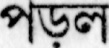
পড়ল
